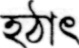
হঠাৎ
